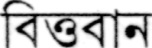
বিত্তবান
